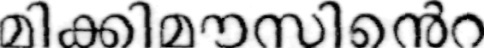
മിക്കിമൌസിന്റെ
